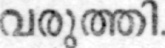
വരുത്തി.
